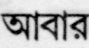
আবার
